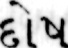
દોષ
